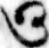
ও
